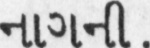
નાગની.
